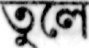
তুলে
